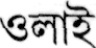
ওলাই
